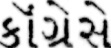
કૉંગ્રેસે
